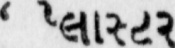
'પ્લાસ્ટર
